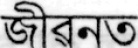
জীৱনত
